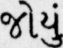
જોયું
